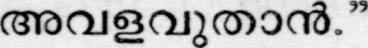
അവളവുതാന്‍.”
